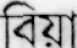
বিয়া
